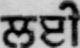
ਲਈ
